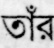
তাঁর
